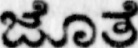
ಜೊತೆ
